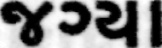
જગ્યા
